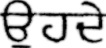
ਉਹਦੇ
